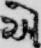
એ
